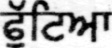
ਫੁੱਟਿਆ
